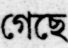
গেছে
